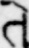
તે
